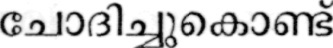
ചോദിച്ചുകൊണ്ട്
